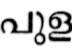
പുള
